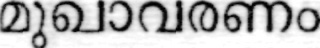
മുഖാവരണം
